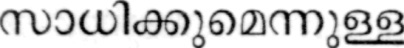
സാധിക്കുമെന്നുള്ള
